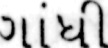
ગાંધી
